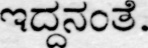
ಇದ್ದನಂತೆ.
